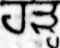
ਹੜ੍ਹ
